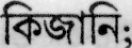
কিজানি;
